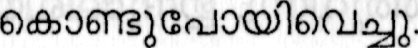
കൊണ്ടുപോയിവെച്ചു.
